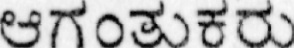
ಆಗಂತುಕರು
